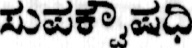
ಸುಪಕ್ವೌಷಧಿ
